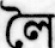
লৈ
